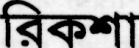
রিকশা
